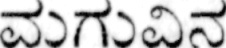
ಮಗುವಿನ
